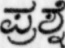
ಪ್ರಶ್ನೆ
